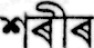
শৰীৰ
